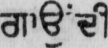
ਗਾਉਂਦੀ
